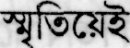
স্মৃতিয়েই
